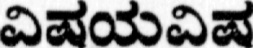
ವಿಷಯವಿಷ
